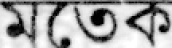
মতেক
